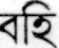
বহি
